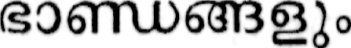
ഭാണ്ഡങ്ങളും
